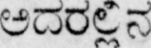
ಅದರಲ್ಲಿನ
